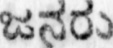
ಜನರು
